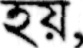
হয়,
